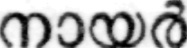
നായര്‍
